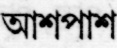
আশপাশ
